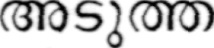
അടുത്ത
